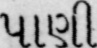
પાણી
